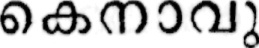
കെനാവു
